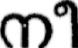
നീ
